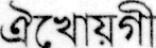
ঐখোয়গী
